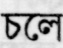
চলে
